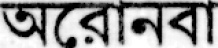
অরোনবা
